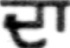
ਦਾ
